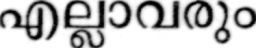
എല്ലാവരും
